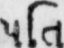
પતિ
